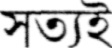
সত্যই
